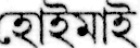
হোইমাই
